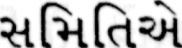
સમિતિએ
